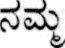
ನಮ್ಮ
